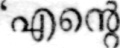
‘എന്റെ
